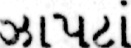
ઝાપટાં
